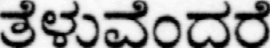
ತೆಳುವೆಂದರೆ
